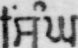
ਸਿੰਘ
